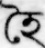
হৈ
